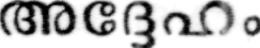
അദ്ദേഹം
